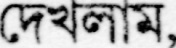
দেখলাম,
